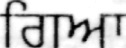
ਗਿਆ
